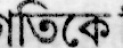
গতিকে
